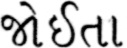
જોઈતા
